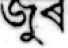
জুৰ
